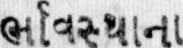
ભાવસ્થાના
